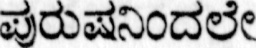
ಪುರುಷನಿಂದಲೇ
